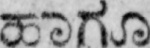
ಹಾಗೂ
